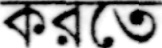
করতে
